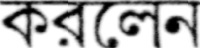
করলেন
